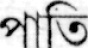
পাতি
